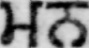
ਮਨ
